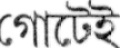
গোটেই
